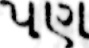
પણ
